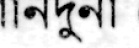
শানদুনা
